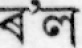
ৰ'ল
